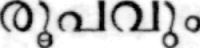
രൂപവും
